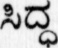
ಸಿದ್ಧ
